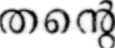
തന്റെ
